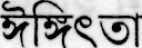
ঈঙ্গিৎতা
